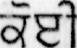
ਕੋਈ
